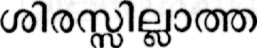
ശിരസ്സില്ലാത്ത
